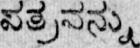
ಪತ್ರವನ್ನು
